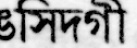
ঙসিদগী
